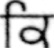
ਕਿ
